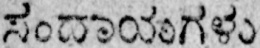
ಸಂದಾಯಗಳು
